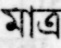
মাত্র
